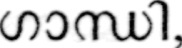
ഗാന്ധി,
